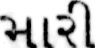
મારી
